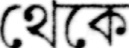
থেকে
